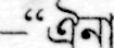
-“ঐনা
